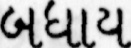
બધાય
